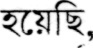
হয়েছি,
